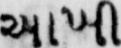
આખી
